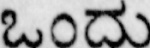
ಒಂದು
